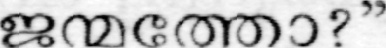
ജന്മത്തോ?"
